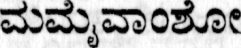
ಮಮೈವಾಂಶೋ
